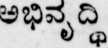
ಅಭಿವೃದ್ಧಿ
